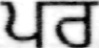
ਪਰ
